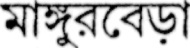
মাঙ্গুরবেড়া
